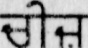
ਚੀਜ਼
